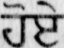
ਹੋਏ
